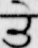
ਤੇ
